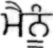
ਮੈਨੂੰ
